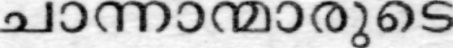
ചാന്നാന്മാരുടെ
